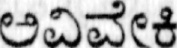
ಅವಿವೇಕಿ
